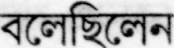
বলেছিলেন
